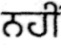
ਨਹੀਂ
